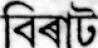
বিৰাট
